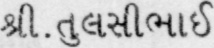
શ્રી.તુલસીભાઈ
